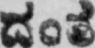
ದಂತೆ
